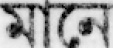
মানে
